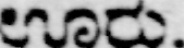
ಊರು.
